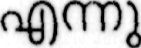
എന്നു
